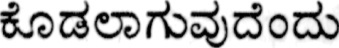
ಕೊಡಲಾಗುವುದೆಂದು
